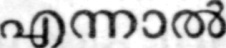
എന്നാല്‍
